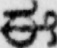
ಈ
